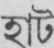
হাট
